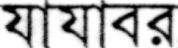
যাযাবর
